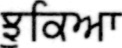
ਝੁਕਿਆ
